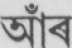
আঁৰ
